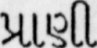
પ્રાણી
